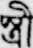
স্ত্রী
